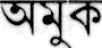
অমুক
